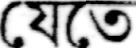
যেতে
